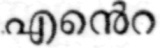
എന്റെ
